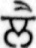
ਲੈ
